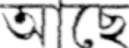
আছে
